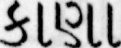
કાણા
